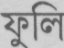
ফুলি
